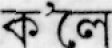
ক'লে
